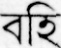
বহি
